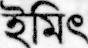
ইমিৎ
